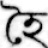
হৈ
